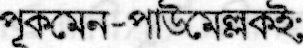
পূকমেন-পাউমেল্লকই;
